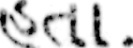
હતા.
